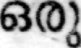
ഒരു
